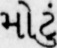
મોટું
